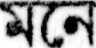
মনে
